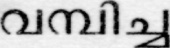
വമ്പിച്ച
